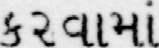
કરવામાં
